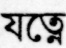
যত্নে
